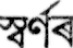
স্বৰ্ণৰ
